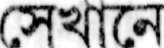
সেখানে
